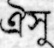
ঐসু
